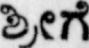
ಶ್ರೀಗೆ
